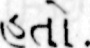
હતો.
